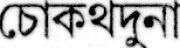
চোকথদুনা
